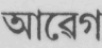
আৱেগ
